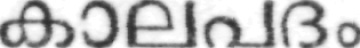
കാലപദം
